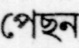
পেছন
